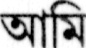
আমি
